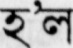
হ'ল
